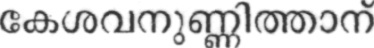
കേശവനുണ്ണിത്താന്
